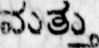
ಮತ್ತು
